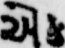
એક
